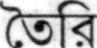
তৈরি
